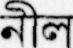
নীল
